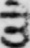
ਤੇ
